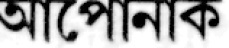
আপোনাক
